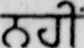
ਨਹੀਂ
